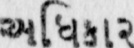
અધિકાર
